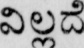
ವಿಲ್ಲದೆ
